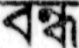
বন্ধ
